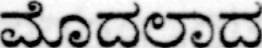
ಮೊದಲಾದ
